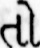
તો
